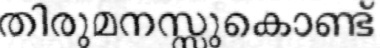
തിരുമനസ്സുകൊണ്ട്
